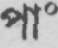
পা
